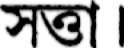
সত্তা।
